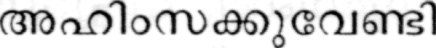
അഹിംസക്കുവേണ്ടി
